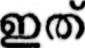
ഇത്
